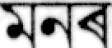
মনৰ
